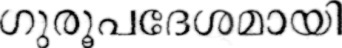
ഗുരൂപദേശമായി
